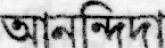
আনন্দিদা
